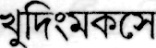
খুদিংমকসে
